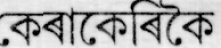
কেৰাকেৰিকৈ
